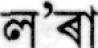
ল'ৰা
